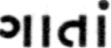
ગાતાં
